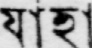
যাহা
